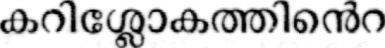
കറിശ്ലോകത്തിന്റെ
